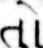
તો
